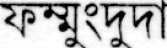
ফম্মুংদুদা
